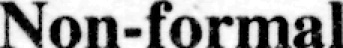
Non-formal
